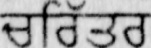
ਚਰਿੱਤਰ
